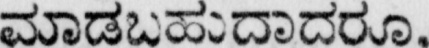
ಮಾಡುಬಹುದಾದರೂ,
